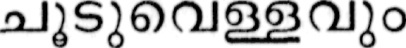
ചൂടുവെള്ളവും
